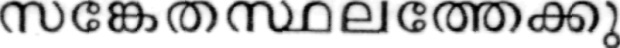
സങ്കേതസ്ഥലത്തേക്കു
